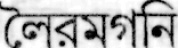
লৈরমগনি
